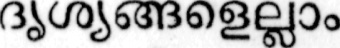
ദൃശ്യങ്ങളെല്ലാം
